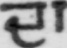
ਦਾ
